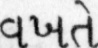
વખતે
